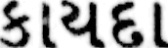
કાયદા
